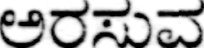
ಅರಸುವ
